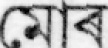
মোৰ
